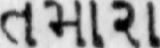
તમારા
